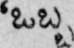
‘ಒಬ್ಬ
